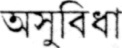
অসুবিধা
